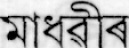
মাধৱীৰ
